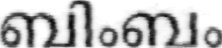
ബിംബം
